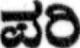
ಪರಿ
